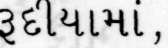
રૂદીયામાં,
